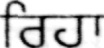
ਰਿਹਾ
